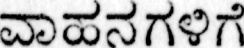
ವಾಹನಗಳಿಗೆ
